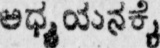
ಅಧ್ಯಯನಕ್ಕೆ
